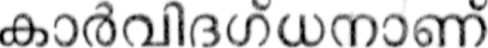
കാര്‍വിദഗ്ധനാണ്
